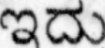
ಇದು
